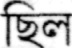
ছিল
